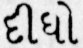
દીધો
